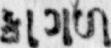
કાગળ
